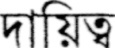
দায়িত্ব
